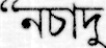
“নচাদু
